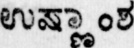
ಉಷ್ಣಾಂಶ
